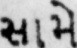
સામે
